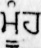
ਮੂੰਹ
